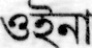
ওইনা
